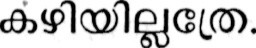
കഴിയില്ലത്രേ.
